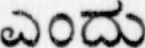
ಎಂದು
